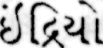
ઇંદ્રિયો
